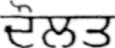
ਦੌਲਤ
